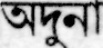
অদুনা
